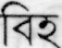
বিহ
